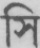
সি
